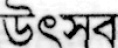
ঊৎসব
